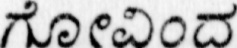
ಗೋವಿಂದ
